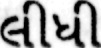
લીધી
